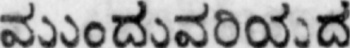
ಮುಂದುವರಿಯದ
